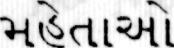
મહેતાઓ
